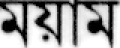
ময়াম
